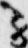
કે
